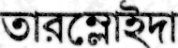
তারম্লোইদা
